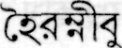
হৈরম্নীবু
